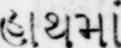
હાથમાં
